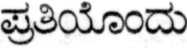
ಪ್ರತಿಯೊಂದು
